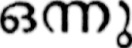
ഒന്നു
